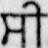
ਸੀ
